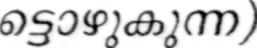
ട്ടൊഴുകുന്ന)
